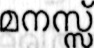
മനസ്സ്
